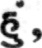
હું,
